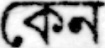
কেন
